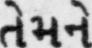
તેમને
